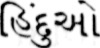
હિંદુઓ
